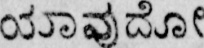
ಯಾವುದೋ
